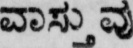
ವಾಸ್ತುವು
